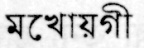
মখোয়গী
